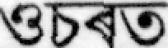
ওচৰত
